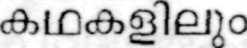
കഥകളിലും
